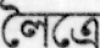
লৈত্রে
